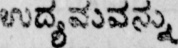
ಉದ್ಯಮವನ್ನು
